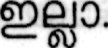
ഇല്ലാ.
